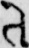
તે
